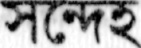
সন্দেহ
